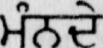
ਮੰਨਦੇ
